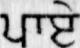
ਪਾਏ
